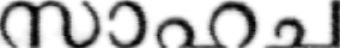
സാഹച
